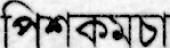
পিশকমচা
